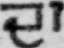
ਦਾ
